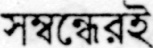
সম্বন্ধেরই
